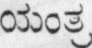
ಯಂತ್ರ
